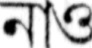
নাও
